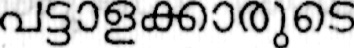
പട്ടാളക്കാരുടെ
